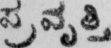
ಪ್ರವೃತ್ತಿ
